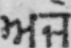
ਅਜੇ
